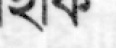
মহাক
